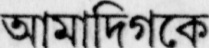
আমাদিগকে
